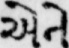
એને
